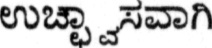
ಉಚ್ಛ್ವಾಸವಾಗಿ
